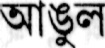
আঙুল
